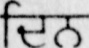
ਦਿਨ
